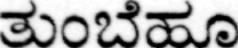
ತುಂಬೆಹೂ
